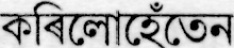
কৰিলোহেঁতেন
